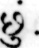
છું.
